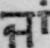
ਜਾਂ
